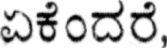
ಏಕೆಂದರೆ,
